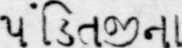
પંડિતજીના
